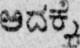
ಅದಕ್ಕೆ
